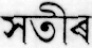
সতীৰ
